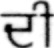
ਦੀ
